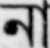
না
